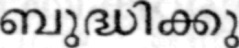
ബുദ്ധിക്കു
